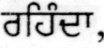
ਰਹਿੰਦਾ,
